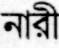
নারী
